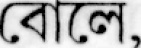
বোলে,
